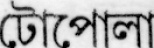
টোপোলা
